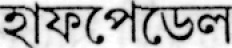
হাফপেডেল
